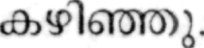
കഴിഞ്ഞു.
